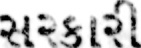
સરકારી
